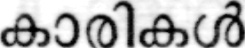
കാരികള്‍
